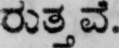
ರುತ್ತವೆ.
